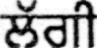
ਲੱਗੀ
